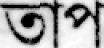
তাপ
